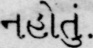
નહોતું.
